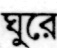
ঘুরে
